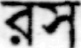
রস
